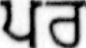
ਪਰ
